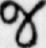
જ
